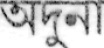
অদুনা
